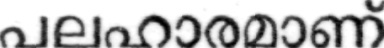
പലഹാരമാണ്
